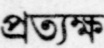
প্রত্যক্ষ
